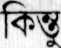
কিন্তু
